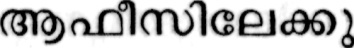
ആഫീസിലേക്കു
